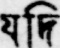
যদি
